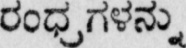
ರಂಧ್ರಗಳನ್ನು
